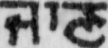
ਜਾਣ
